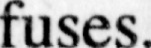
fuses.
